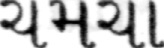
ચમચા
